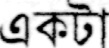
একটা
